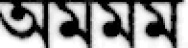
অমমম
